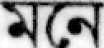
মনে
